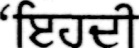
'ਇਹਦੀ
